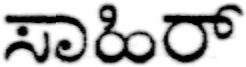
ಸಾಹಿರ್
